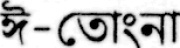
ঈ-তোংনা
